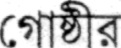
গোষ্ঠীর
